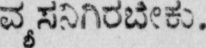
ವ್ಯಸನಿಗಿರಬೇಕು.
